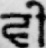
ਵੀ
